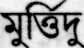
মুর্ত্তিদু
